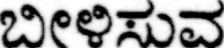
ಬೀಳಿಸುವ
